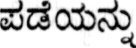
ಪಡೆಯನ್ನು
